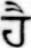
ਹੈ
